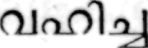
വഹിച്ച
